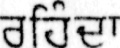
ਰਹਿੰਦਾ
